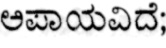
ಅಪಾಯವಿದೆ;
